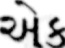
એક
